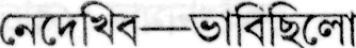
নেদেখিব-ভাবিছিলো
